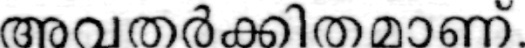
അവതര്‍ക്കിതമാണ്.
